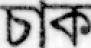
চাক
